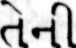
તેની
